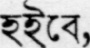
হইবে,
